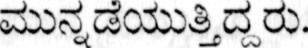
ಮುನ್ನಡೆಯುತ್ತಿದ್ದರು.
